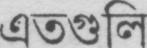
এতগুলি
